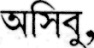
অসিবু,
